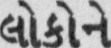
લોકોને
